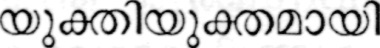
യുക്തിയുക്തമായി
